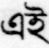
এই
